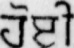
ਹੋਈ
